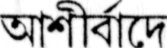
আশীর্বাদে
